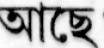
আছে
